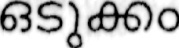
ഒടുക്കം
